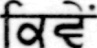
ਕਿਵੇਂ
